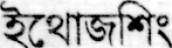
ইথোজশিং
